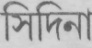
সিদিনা
